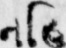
નહિ
